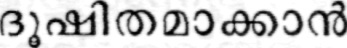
ദൂഷിതമാക്കാന്‍
